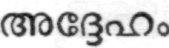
അദ്ദേഹം
